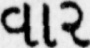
વાર
